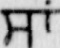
ਸਾਂ
